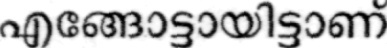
എങ്ങോട്ടായിട്ടാണ്
